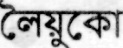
লৈয়ুকো
